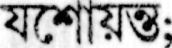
যশোয়ন্ত;
